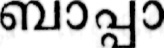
ബാപ്പാ
